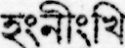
হংনীংখি
